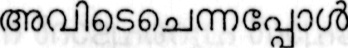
അവിടെചെന്നപ്പോള്‍
